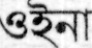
ওইনা
